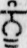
ਨੂੰ
